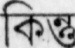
কিন্তু
